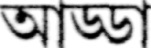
আড্ডা
